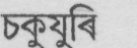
চকুযুৰি
